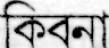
কিবনা
